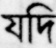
যদি
